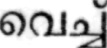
വെച്ച്
